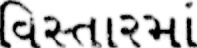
વિસ્તારમાં
